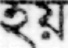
হয়
